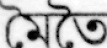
মৈতৈ
